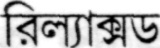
রিল্যাক্সড
